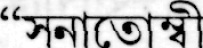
“সনাতোম্বী
